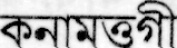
কনামত্তগী
